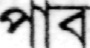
পাব
